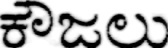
ಕೌಜಲು
